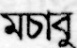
মচাবু
